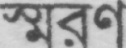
স্মরণ
